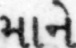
માને
